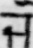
ਜੋ
